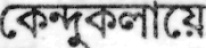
কেন্দুকলায়ে
